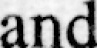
and
